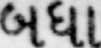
બધા
